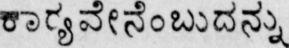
ಕಾರ್‍ಯವೇನೆಂಬುದನ್ನು
